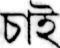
চাই
